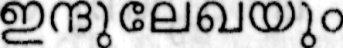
ഇന്ദുലേഖയും
